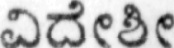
ವಿದೇಶೀ
